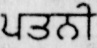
ਪਤਨੀ
